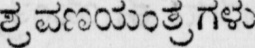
ಶ್ರವಣಯಂತ್ರಗಳು
